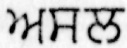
ਅਸਲ
